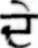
ਦੇ
